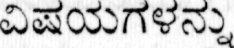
ವಿಷಯಗಳನ್ನು
